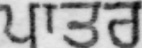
ਪਾਤਰ
